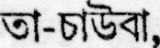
তা-চাউবা,
